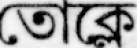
তোক্লে
